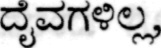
ದೈವಗಳಿಲ್ಲ,
